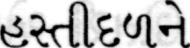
હસ્તીદળને
